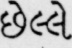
છેલ્લે
